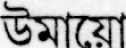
উমায়ো
